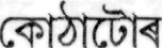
কোঠাটোৰ
